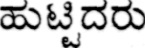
ಹುಟ್ಟಿದರು
